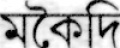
মকৈদি
